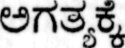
ಅಗತ್ಯಕ್ಕೆ
